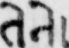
તેનો
